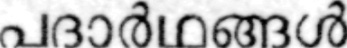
പദാര്‍ഥങ്ങള്‍
